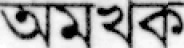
অমখক
